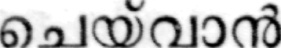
ചെയ്വാന്‍
